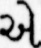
એ
